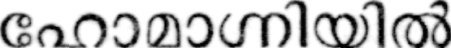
ഹോമാഗ്നിയില്‍
